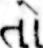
તો
